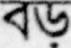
বড়
